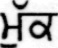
ਮੁੱਕ
